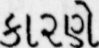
કારણે
